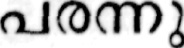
പരന്നു
